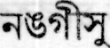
নঙগীসু
